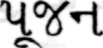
પૂજન
